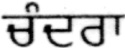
ਚੰਦਰਾ
